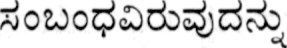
ಸಂಬಂಧವಿರುವುದನ್ನು
